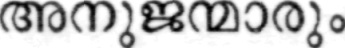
അനുജന്മാരും
